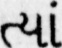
ત્યાં
